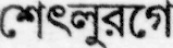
শেৎলুরগে
